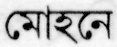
মোহনে
